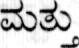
ಮತ್ತು
